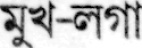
মুখ-লগা
